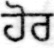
ਹੋਰ
